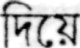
দিয়ে
